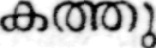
കത്തു
